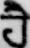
ਹੈ
